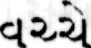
વચ્ચે
